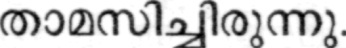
താമസിച്ചിരുന്നു.
